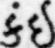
કંઈ
